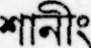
শানীং
